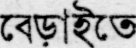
বেড়াইতে
